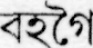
বহগৈ
